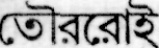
তৌররোই
